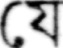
যে
